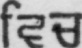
ਵਿਚ
